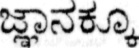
ಜ್ಞಾನಕ್ಕೂ
